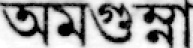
অমগুম্না
